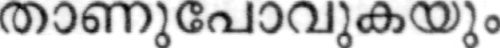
താണുപോവുകയും
